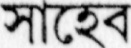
সাহেব
